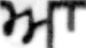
ਆ
